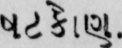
ષટકોણ.
